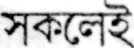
সকলেই
